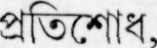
প্রতিশোধ,
